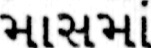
માસમાં
